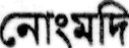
নোংমদি
